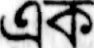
এক
